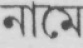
নামে
